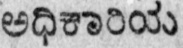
ಅಧಿಕಾರಿಯ
